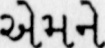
એમને
